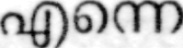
എന്നെ
